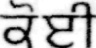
ਕੋਈ
